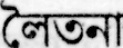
লৈতনা
